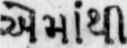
એમાંથી
